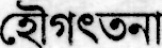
হৌগৎতনা
